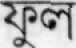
ফুল
